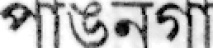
পাঙনগা
